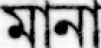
মানা
